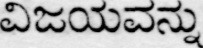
ವಿಜಯವನ್ನು
